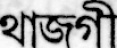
থাজগী
